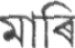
মাৰি
